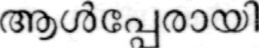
ആള്‍പ്പേരായി
